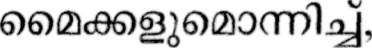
മൈക്കളുമൊന്നിച്ച്,
